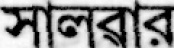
সালৱার
